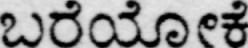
ಬರೆಯೋಕೆ
